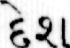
દેશ
